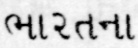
ભારતના
